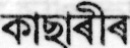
কাছাৰীৰ
